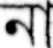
না
